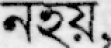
নহয়,
